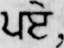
ਪਏ,
